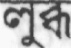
লুব্ধ
